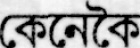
কেনেকৈ
